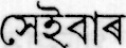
সেইবাৰ
